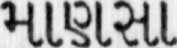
માણસા
